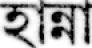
হান্না
